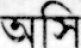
অসি
